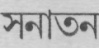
সনাতন
